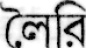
লৈরি
